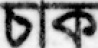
চাক
